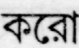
করো
